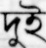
দুই
